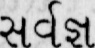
સર્વજ્ઞ
